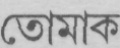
তোমাক
